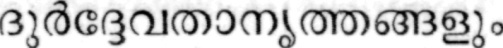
ദുര്‍ദ്ദേവതാനൃത്തങ്ങളും
